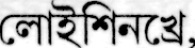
লোইশিনখ্রে,
